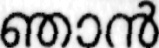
ഞാന്‍
